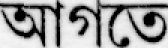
আগতে
